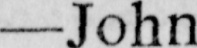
-John
